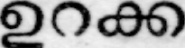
ഉറക്ക
